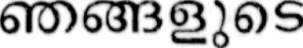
ഞങ്ങളുടെ
